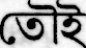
তৌই
